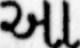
આ
